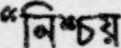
‘‘নিশ্চয়
